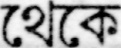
থেকে
